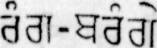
ਰੰਗ-ਬਰੰਗੇ
